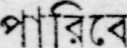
পারিবে
